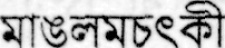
মাঙলমচৎকী
